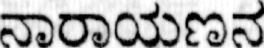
ನಾರಾಯಣನ
